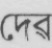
দেৱ
